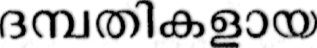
ദമ്പതികളായ
